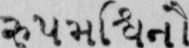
રુપમાશ્વિનૌ
